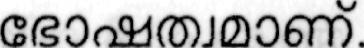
ഭോഷത്വമാണ്.
